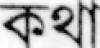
কথা
